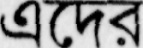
এদের
